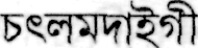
চৎলমদাইগী
